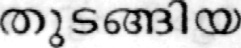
തുടങ്ങിയ
